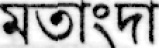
মতাংদা
